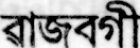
ৱাজবগী
